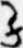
કે
